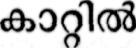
കാറ്റില്‍
